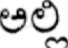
ಅಲ್ಲಿ
